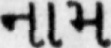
નામ
